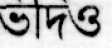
ভিদিও
